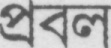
প্রবল
